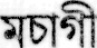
মচাগী
